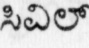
ಸಿವಿಲ್
